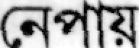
নেপায়
